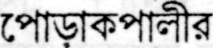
পোড়াকপালীর
